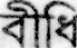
বীধি
